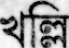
খল্লি
